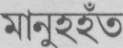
মানুহহঁত
